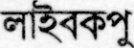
লাইবকপু
